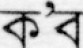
ক'ব
